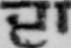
ਦਾ
